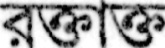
রক্তাক্ত
